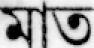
মাত
